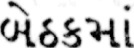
બેઠકમાં
